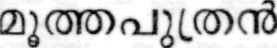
മൂത്തപുത്രന്‍
